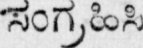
ಸಂಗ್ರಹಿಸಿ
